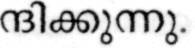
ന്ദിക്കുന്നു.
